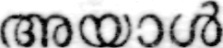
അയാള്‍
